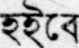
হইবে
